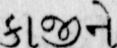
કાજીને
